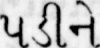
પડીને
